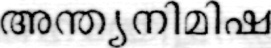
അന്ത്യനിമിഷ
